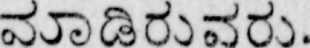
ಮಾಡಿರುವರು.
